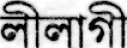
লীলাগী
